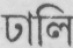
ঢালি
